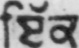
ਇੱਕ
